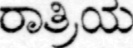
ರಾತ್ರಿಯ
